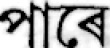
পাৰে
